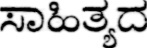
ಸಾಹಿತ್ಯದ
